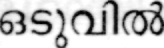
ഒടുവില്‍
